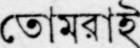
তোমরাই
